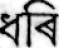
ধৰি
